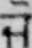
ਜੋ
